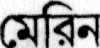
মেরিন
